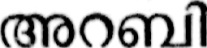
അറബി
